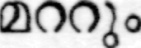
മററും
